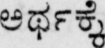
ಅರ್ಥಕ್ಕೆ
